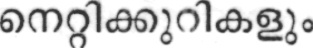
നെറ്റിക്കുറികളും
